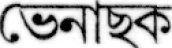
ভেনাছক
